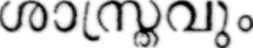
ശാസ്ത്രവും
